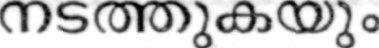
നടത്തുകയും
